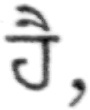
ਹੈ,
